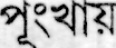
পূংখায়
